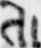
તો
